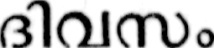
ദിവസം
